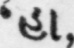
'હા,
